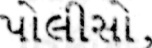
પોલીસો,
